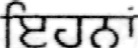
ਇਹਨਾਂ
